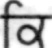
ਕਿ
